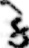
કે
